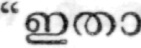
"ഇതാ
